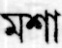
মশা
